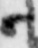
ન
